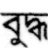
বুদ্ধ
